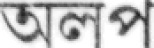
অলপ
